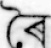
ৰৈ
